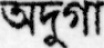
অদুগা
